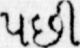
પછી
